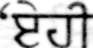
'ਏਹੀ
